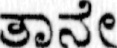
ತಾನೇ
